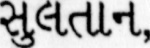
સુલતાન,
